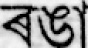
ৰঙা
